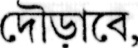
দৌড়াবে,
